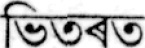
ভিতৰত
